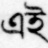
এই
